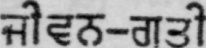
ਜੀਵਨ-ਗਤੀ
